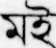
মই
